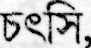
চৎসি,
